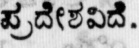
ಪ್ರದೇಶವಿದೆ.
